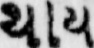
થાય
